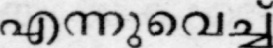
എന്നുവെച്ച്
